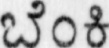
ಬೆಂಕಿ
